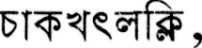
চাকখৎলক্লি,
